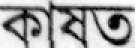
কাষত
